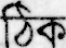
ঠিক
